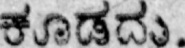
ಕೂಡದು.
